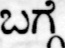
ಬಗ್ಗೆ
